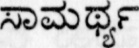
ಸಾಮರ್ಥ್ಯ
